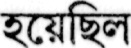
হয়েছিল
